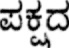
ಪಕ್ಷದ
